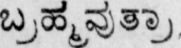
ಬ್ರಹ್ಮವುತ್ರಾ,
